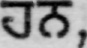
ਹਨ,
